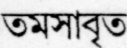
তমসাবৃত
